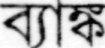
ব্যাঙ্ক
